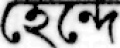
হেন্দে
